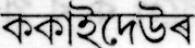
ককাইদেউৰ
